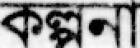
কল্পনা
